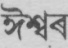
ঈশ্বৰ
